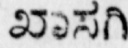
ಖಾಸಗಿ
